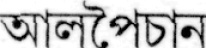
আলপৈচান
